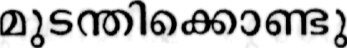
മുടന്തിക്കൊണ്ടു
